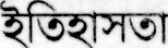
ইতিহাসতা
